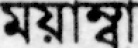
ময়াম্বা
